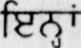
ਇਨ੍ਹਾਂ
